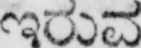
ಇರುವ
